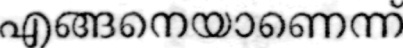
എങ്ങനെയാണെന്ന്
